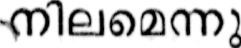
നിലമെന്നു
